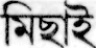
মিছাই
